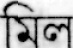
মিল
